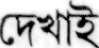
দেখাই
